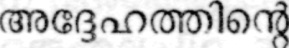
അദ്ദേഹത്തിന്റെ
